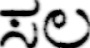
ಸಲ
